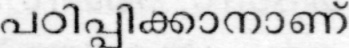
പഠിപ്പിക്കാനാണ്
